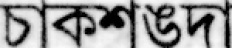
চাকশঙদা
